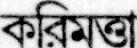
করিমত্তা
